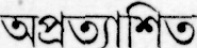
অপ্রত্যাশিত
